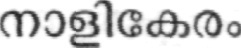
നാളികേരം
